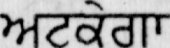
ਅਟਕੇਗਾ
